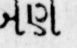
એણે
